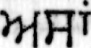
ਅਸਾਂ
